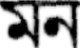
মন
